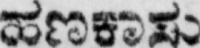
ಹಣಕಾಸು
